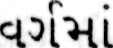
વર્ગમાં
